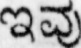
ಇವು
